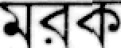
মরক
